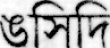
ঙসিদি
